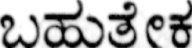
ಬಹುತೇಕ
